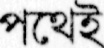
পথেই
